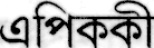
এপিককী
